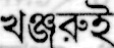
খঞ্জরুই
